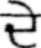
ਦੇ
